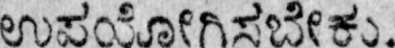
ಉಪಯೋಗಿಸಬೇಕು.
